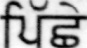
ਪਿੱਛੇ
